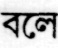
বলে
